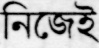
নিজেই
